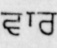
ਵਾਰ
